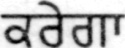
ਕਰੇਗਾ
